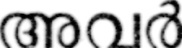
അവര്‍
